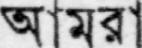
আমরা
